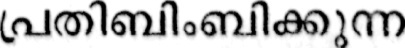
പ്രതിബിംബിക്കുന്ന
